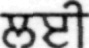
ਲਈ
